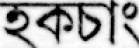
হকচাং
